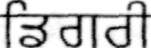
ਡਿਗਰੀ
